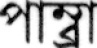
পাম্ব্রা
